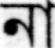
না
